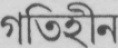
গতিহীন
